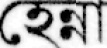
হেন্না
